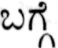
ಬಗ್ಗೆ
